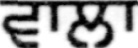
ਵਾਲਾ
